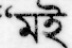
"মই
